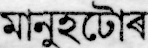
মানুহটোৰ
